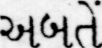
અબતેં
